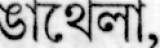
ঙাথেলা,
